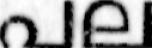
പല
